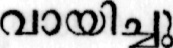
വായിച്ചു
